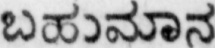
ಬಹುಮಾನ
